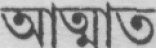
আত্মাত
